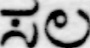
ಸಲ
